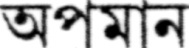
অপমান
